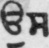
ਉਸ
